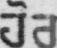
ਹੋਰ
